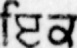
ਇਕ
